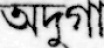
অদুগা
